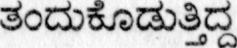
ತಂದುಕೊಡುತ್ತಿದ್ದ
